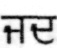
ਜਦ
